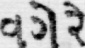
વગેરે
